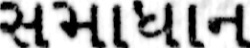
સમાધાન
